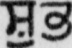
ਸ਼ੁਭ
